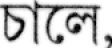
চালে,
